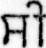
ਸੀ
